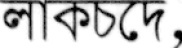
লাকচদে,
